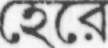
হেরে
